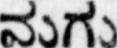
ಮಗು
